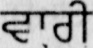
ਵਾਰੀ
